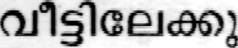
വീട്ടിലേക്കു
